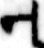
ન
